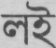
লই
